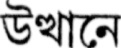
উত্থানে
